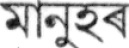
মানুহৰ
